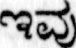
ಇವು
